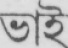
ভাই
